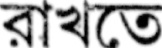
রাখতে
